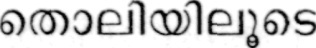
തൊലിയിലൂടെ
